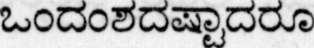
ಒಂದಂಶದಷ್ಟಾದರೂ
